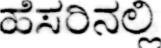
ಹೆಸರಿನಲ್ಲಿ
